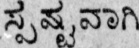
ಸ್ಪಷ್ಟವಾಗಿ
